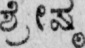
ಶ್ರೇಷ್ಠ
